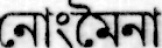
নোংমৈনা
